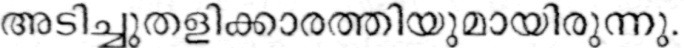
അടിച്ചുതളിക്കാരത്തിയുമായിരുന്നു.
